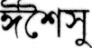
ঈশৈসু
